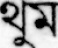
থুম
